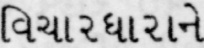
વિચારધારાને
